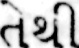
તેથી
